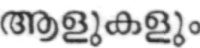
ആളുകളും
